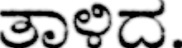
ತಾಳಿದ.
